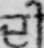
ਦੀ
